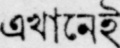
এখানেই
